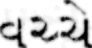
વચ્ચે
